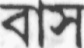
বাস
